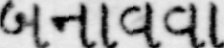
બનાવવા
